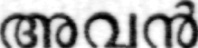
അവന്‍
